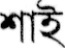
শাই
